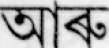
আৰু
